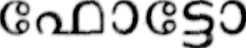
ഫോട്ടോ
